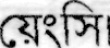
য়েংসি।
